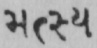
મત્સ્ય
